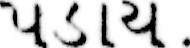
પડાય.
